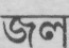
জল
